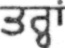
ਤਰ੍ਹਾਂ
